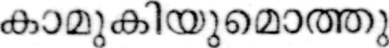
കാമുകിയുമൊത്തു
